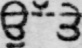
ਉੱਤੇ
